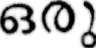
ഒരു
